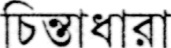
চিন্তাধারা
